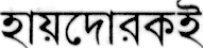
হায়দোরকই
